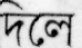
দিলে
